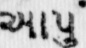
આપું
